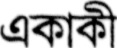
একাকী
